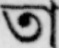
তা
